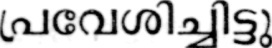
പ്രവേശിച്ചിട്ടു
